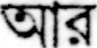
আর
